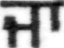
ਜਾ
